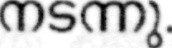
നടന്നു.
